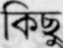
কিছু
